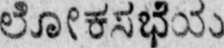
ಲೋಕಸಭೆಯ
